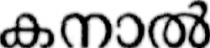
കനാല്‍
